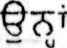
ਉਨ੍ਹਾਂ
